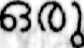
ഒരു
